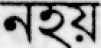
নহয়
